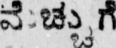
ಮೆಚ್ಚುಗೆ
